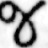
જ
